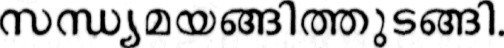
സന്ധ്യമയങ്ങിത്തുടങ്ങി.
